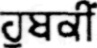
ਹੁਬਕੀਂ
